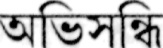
অভিসন্ধি
